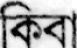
কিবা
